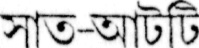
সাত-আটটি
